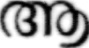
ആ
